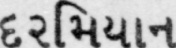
દરમિયાન
